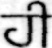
ਹੀ
